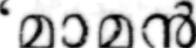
'മാമന്‍
